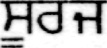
ਸੂਰਜ
